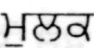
ਮੁਲਕ
